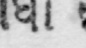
લીધા
